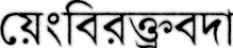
য়েংবিরক্ত্রবদা
